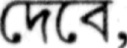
দেবে,
